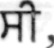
ਸੀ,
